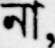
না,
